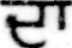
ਦਾ
